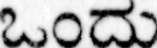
ಒಂದು
